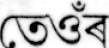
তেওঁৰ
